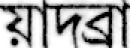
য়াদব্রা
